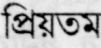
প্রিয়তম
